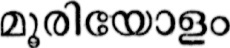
മൂരിയോളം
